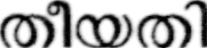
തീയതി
